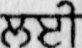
ਲਈ
